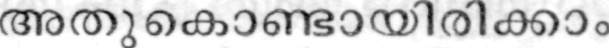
അതുകൊണ്ടായിരിക്കാം
